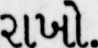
રાખો.
